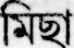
মিছা
